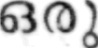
ഒരു
